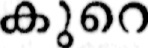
കുറെ
